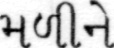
મળીને
